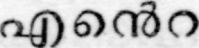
എന്റെ
